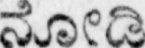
ನೋಡಿ
